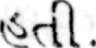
હતી.
